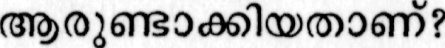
ആരുണ്ടാക്കിയതാണ്?
